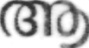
ആ
